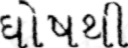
ઘોષથી
